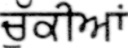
ਚੁੱਕੀਆਂ
